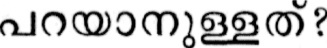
പറയാനുള്ളത്?
